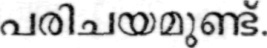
പരിചയമുണ്ട്.
